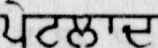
ਪੇਟਲਾਦ
